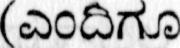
(ಎಂದಿಗೂ
